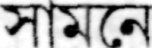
সামনে
